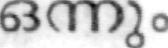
ഒന്നും
